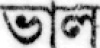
ভাল
